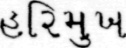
હરિમુખ
